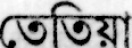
তেতিয়া
